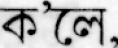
ক'লে,
